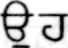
ਉਹ
